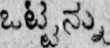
ಒಟ್ಟನ್ನು
